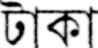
টাকা
